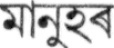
মানুহৰ
